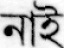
নাই
